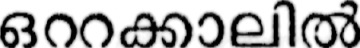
ഒററക്കാലില്‍
